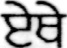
ਏਥੇ
